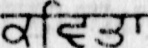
ਕਵਿਤਾ
